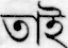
তাই
